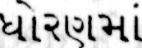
ધોરણમાં
